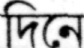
দিনে
